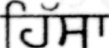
ਹਿੱਸਾ
